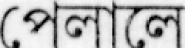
পেলালে
